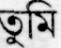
তুমি
